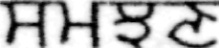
ਸਮਝਣ
